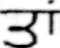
ਤਾਂ
